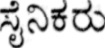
ಸೈನಿಕರು
